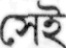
সেই
